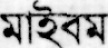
মাইবম
